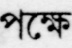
পক্ষে
